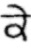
ਕੇ
